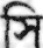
সি
